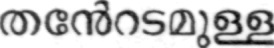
തന്റേടമുള്ള
